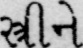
સ્ત્રીને
